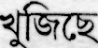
খুজিছে
